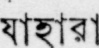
যাহারা
